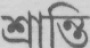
শ্ৰান্তি
